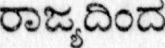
ರಾಜ್ಯದಿಂದ
